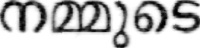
നമ്മുടെ
